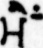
ਮੈਂ
